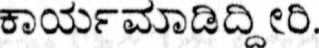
ಕಾರ್ಯಮಾಡಿದ್ದೀರಿ.
